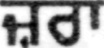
ਜ਼ਰਾ
